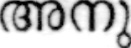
അനു
